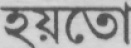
হয়তো
